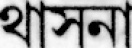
থাসনা
